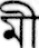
মী
